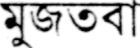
মুজতবা
